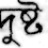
দুষ্ট
